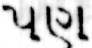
પણ
